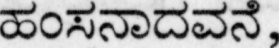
ಹಂಸನಾದವನೆ,
